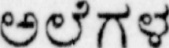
ಅಲೆಗಳ
